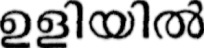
ഉളിയില്‍
